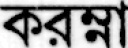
করম্না
